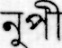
নুপী
